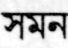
সমন
